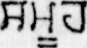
ਸਮੂਹ
